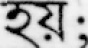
হয়;
